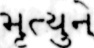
મૂત્યુને
